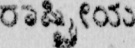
ರಾಷ್ಟ್ರೀಯ
